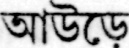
আউড়ে
